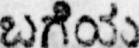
ಬಗೆಯ
